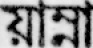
য়াম্না
